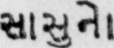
સાસુનો
